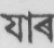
যাৰ
